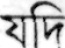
যদি
